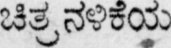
ಚಿತ್ರನಳಿಕೆಯ
